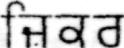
ਜ਼ਿਕਰ
